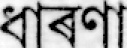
ধাৰণা
